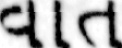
વાત
